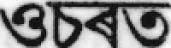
ওচৰত
